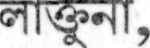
লাক্তুনা,
